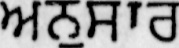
ਅਨੁਸਾਰ
